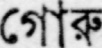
গোরু
